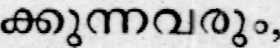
ക്കുന്നവരും,
